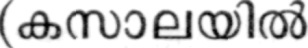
(കസാലയില്‍
